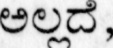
ಅಲ್ಲದೆ,
